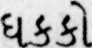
ધકકો
